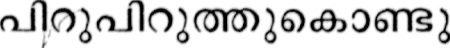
പിറുപിറുത്തുകൊണ്ടു
